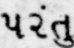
પરંતુ
